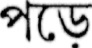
পড়ে
